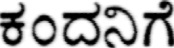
ಕಂದನಿಗೆ
